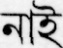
নাই
